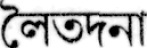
লৈতদনা
